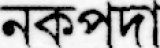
নকপদা
